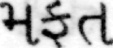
મફત
